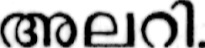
അലറി.
